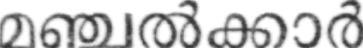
മഞ്ചല്‍ക്കാര്‍
